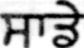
ਸਾਡੇ
